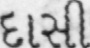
દાસી
